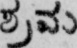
ಶ್ರಮ
